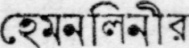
হেমনলিনীর
